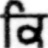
ਕਿ
